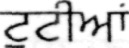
ਟੁਟੀਆਂ
